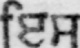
ਇਸ
